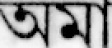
অমা
